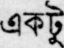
একটু
